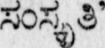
ಸಂಸ್ಕೃತಿ’
